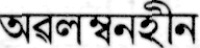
অৱলম্বনহীন
